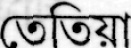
তেতিয়া
